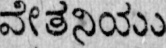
ವೇತನಿಯು
